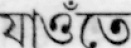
যাওঁতে
